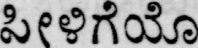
ಪೀಳಿಗೆಯೊ
